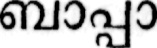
ബാപ്പാ
